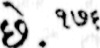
છે.૧૭૬
